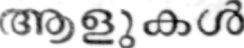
ആളുകള്‍
